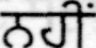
ਨਹੀਂ
